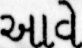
આવે
